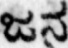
ಜನ
